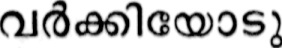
വര്‍ക്കിയോടു
